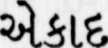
એકાદ
